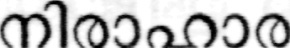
നിരാഹാര
